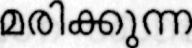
മരിക്കുന്ന
